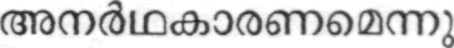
അനര്‍ഥകാരണമെന്നു
